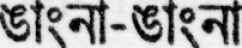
ঙাংনা-ঙাংনা
